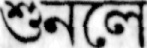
শুনলে
